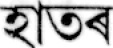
হাতৰ
